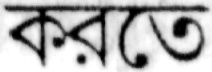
করতে
